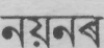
নয়নৰ
